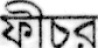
ফীচর
